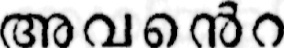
അവന്റെ
